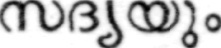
സദ്യയും
